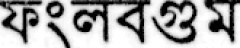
ফংলবগুম
